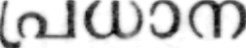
പ്രധാന
